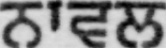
ਨਾਵਲ
